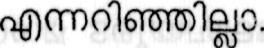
എന്നറിഞ്ഞില്ലാ.
